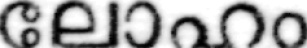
ലോഹം
